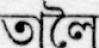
তালৈ
